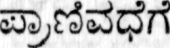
ಪ್ರಾಣಿವಧೆಗೆ
